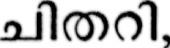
ചിതറി,
